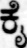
ಕೈ
